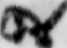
જ
